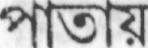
পাতায়
